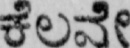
ಕೆಲವೇ
